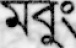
মবুং
